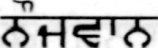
ਨੌਜਵਾਨ
